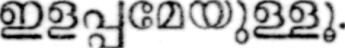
ഇളപ്പമേയുള്ളൂ.
